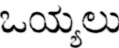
ಒಯ್ಯಲು
